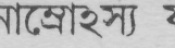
নাম্ৰোহস্য
